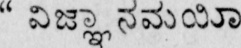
“ವಿಜ್ಞಾನಮಯಿ
